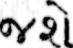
જશે
